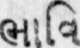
ભાવિ
